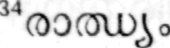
34രാഝ്യം
